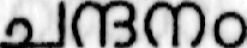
ചന്ദനം
